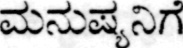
ಮನುಷ್ಯನಿಗೆ
